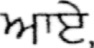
ਆਏ,
